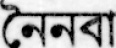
নৈনবা
